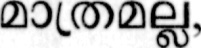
മാത്രമല്ല,
